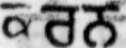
ਕਰਨ
